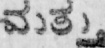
ಮತ್ತು
